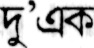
দু'এক
